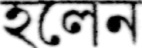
হলেন
